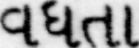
વધતા
